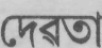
দেৱতা
